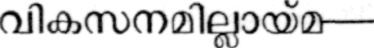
വികസനമില്ലായ്മ-
